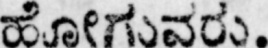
ಹೋಗುವರು.
